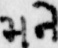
મને
